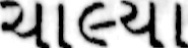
ચાલ્યા
